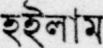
হইলাম
